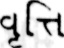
વૃત્તિ
